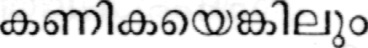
കണികയെങ്കിലും
